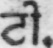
ਟੀ.
